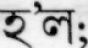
হ'ল;
